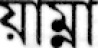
য়াম্না
